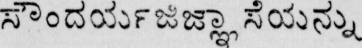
ಸೌಂದರ್ಯಜಿಜ್ಞಾಸೆಯನ್ನು
